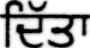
ਦਿੱਤਾ
